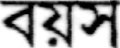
বয়স
